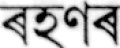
ৰহণৰ
